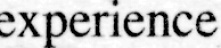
experience\
